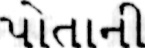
પોતાની
